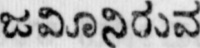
ಜಮೀನಿರುವ
